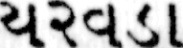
યરવડા
